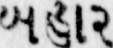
બહાર
